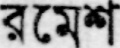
রমেশ
